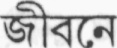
জীবনে
